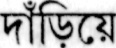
দাঁড়িয়ে
